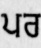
ਪਰ
